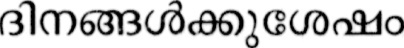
ദിനങ്ങള്‍ക്കുശേഷം
